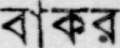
বাকর
